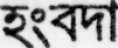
হংবদা
